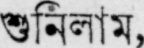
শুনিলাম,
